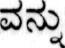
ವನ್ನು
